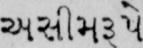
રૂપે
